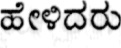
ಹೇಳಿದರು
